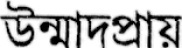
উন্মাদপ্রায়
